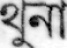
থুনা
